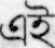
এই
